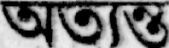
অত্যন্ত
